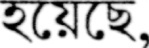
হয়েছে,
